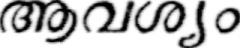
ആവശ്യം
